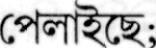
পেলাইছে;
